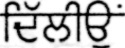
ਦਿੱਲੀਉਂ
